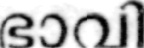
ഭാവി
